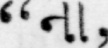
"ના,
